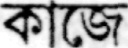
কাজে
